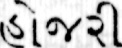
હોજરી
